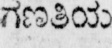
ಗಣತಿಯ
